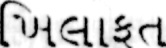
ખિલાફત
